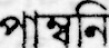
পাম্বনি
